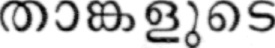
താങ്കളുടെ
